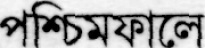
পশ্চিমফালে
